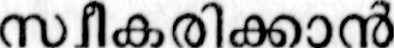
സ്വീകരിക്കാന്‍
